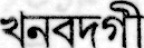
খনবদগী
